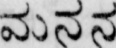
ಮನನ
